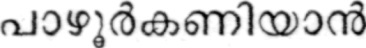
പാഴൂര്‍കണിയാന്‍
